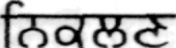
ਨਿਕਲਣ
